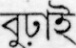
বুঢ়াই
